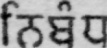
ਨਿਬੰਧ
